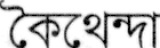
কৈথেন্দা
